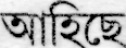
আহিছে
